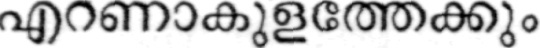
എറണാകുളത്തേക്കും
